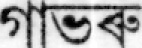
গাভৰু
